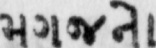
મગજનો
